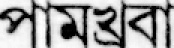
পামখ্রবা
